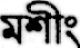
মশীং
